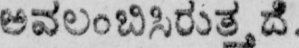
ಅವಲಂಬಿಸಿರುತ್ತದೆ.
